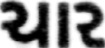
ચાર
